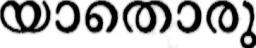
യാതൊരു
